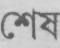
শেষ
